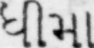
ધીમા
